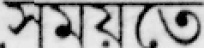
সময়তে
